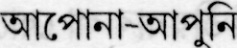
আপোনা-আপুনি
